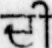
ਦੀ
